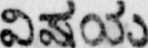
ವಿಷಯ
